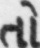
તો
